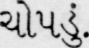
ચોપડું.
